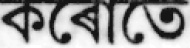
কৰোতে
